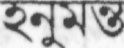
হনুমন্ত
